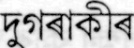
দুগৰাকীৰ
